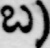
ಬ)
